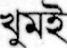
খুমই
